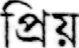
প্রিয়
